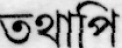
তথাপি
